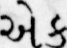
એક
